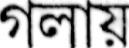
গলায়
